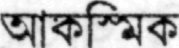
আকস্মিক
